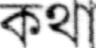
কথা
